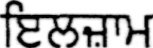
ਇਲਜ਼ਾਮ
